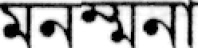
মনম্মনা
